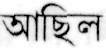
আছিল
